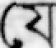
যে
